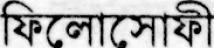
ফিলোসোফী
